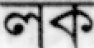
লক
